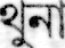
থুনা
